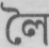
লৈ
